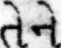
તેને
